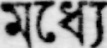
মধ্যে
